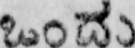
ಒಂದು
